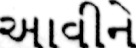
આવીને
